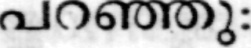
പറഞ്ഞു:
